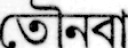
তৌনবা
